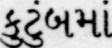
કુટુંબમાં
